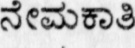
ನೇಮಕಾತಿ
